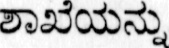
ಶಾಖೆಯನ್ನು
